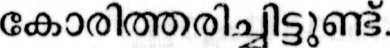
കോരിത്തരിച്ചിട്ടുണ്ട്.
